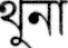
থুনা
